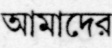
আমাদের
